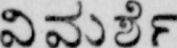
ವಿಮರ್ಶೆ
